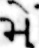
મેં
